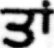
ਤਾਂ
